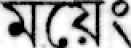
ময়েং
